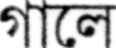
গালে
